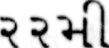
૨૨મી
